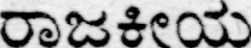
ರಾಜಕೀಯ
